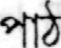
পাঠ
